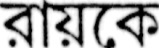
রায়কে
